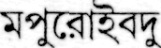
মপুরোইবদু
